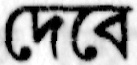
দেবে
